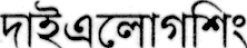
দাইএলোগশিং
